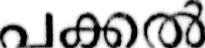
പക്കല്‍
